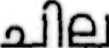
ചില
